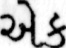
એક
